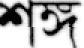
শঙ্গু
